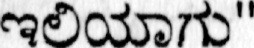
ಇಲಿಯಾಗು”
